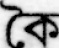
কৈ
